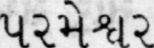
પરમેશ્વર
